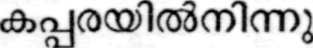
കപ്പരയില്‍നിന്നു
